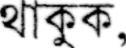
থাকুক,
